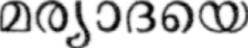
മര്യാദയെ
